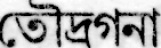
তৌদ্রগনা
